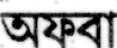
অফবা
